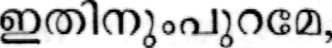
ഇതിനുംപുറമേ,
